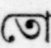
তো
